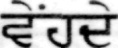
ਵੇਂਹਦੇ
